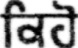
ਕਿਹੋ
